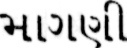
માગણી
